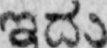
ಇದು
